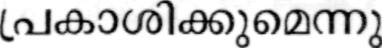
പ്രകാശിക്കുമെന്നു
